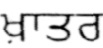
ਖ਼ਾਤਰ
